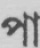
পা
